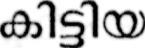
കിട്ടിയ
